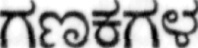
ಗಣಕಗಳ
